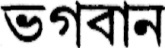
ভগবান
